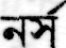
নর্স
